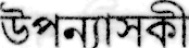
উপন্যাসকী
